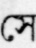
সে
